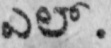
ಎಲ್.
